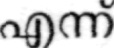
എന്ന്
